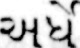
અર્ધે
